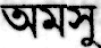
অমসু
